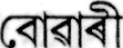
বোৱাৰী
